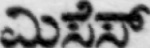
ಮಿಸೆಸ್
